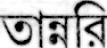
তান্নরি
